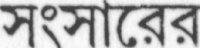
সংসারের
